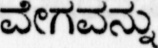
ವೇಗವನ್ನು
